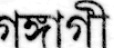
ঙঙ্গাগী
